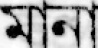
মানা
